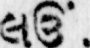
લઉં.
